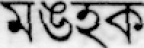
মঙহক
